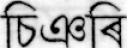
চিঞৰি
